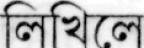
লিখিলে
